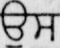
ਉਸ
